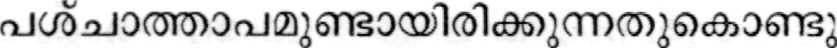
പശ് ചാത്താപമുണ്ടായിരിക്കുന്നതുകൊണ്ടു
